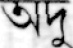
অদু
